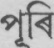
পূৰি
